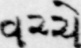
વચ્ચે
